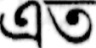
এত
